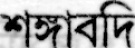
শঙ্গাবদি
